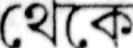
থেকে
